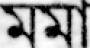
মমা
